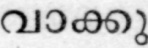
വാക്കു
